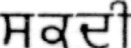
ਸਕਦੀ
